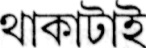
থাকাটাই
